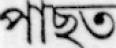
পাছত
